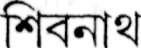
শিবনাথ
